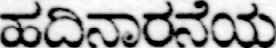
ಹದಿನಾರನೆಯ
